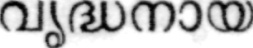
വൃദ്ധനായ
